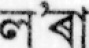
ল'ৰা
